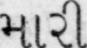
મારી
